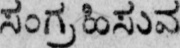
ಸಂಗ್ರಹಿಸುವ
